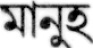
মানুহ
